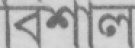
বিশাল
